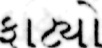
ફાટ્યો
